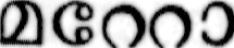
മറേറാ
